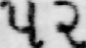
પર
